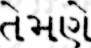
તેમણે
